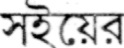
সইয়ের
